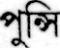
পুন্সি
